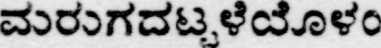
ಮರುಗದಟ್ಟಳೆಯೊಳಂ
